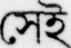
সেই
